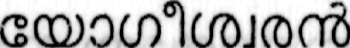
യോഗീശ്വരന്‍
